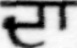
ਦਾ
